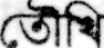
তৌখি
